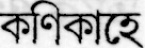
কণিকাহে
